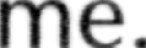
me.
